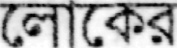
লোকের
